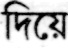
দিয়ে
